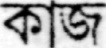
কাজ
